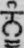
ਨੂੰ
